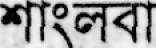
শাংলবা
